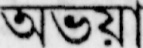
অভয়া
